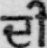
ਦੀ
